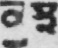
ਕੁਝ
